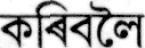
কৰিবলৈ
